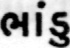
ભાંડુ
